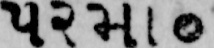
પરમા.
